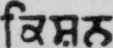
ਕਿਸ਼ਨ
